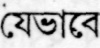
যেভাবে
